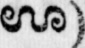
ಊ)
